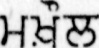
ਮਖ਼ੌਲ
